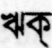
ঋক্
